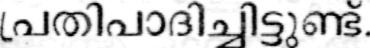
പ്രതിപാദിച്ചിട്ടുണ്ട്.
